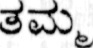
ತಮ್ಮ
